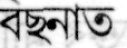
বিছনাত
